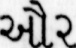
ઔર
